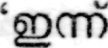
‘ഇന്ന്
